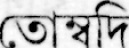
তোম্বদি
